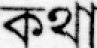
কথা
